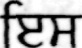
ਇਸ
